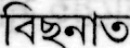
বিছনাত
